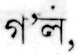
গ'ল,
